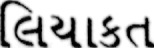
લિયાકત
